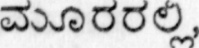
ಮೂರರಲ್ಲಿ,
